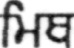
ਮਿਥ
